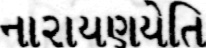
નારાયણયેતિ
